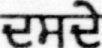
ਦਸਦੇ
